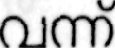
വന്ന്
